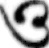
ও
